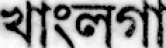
খাংলগা
